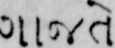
ગાજતે
